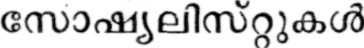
സോഷ്യലിസ്റ്റുകള്‍
